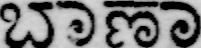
ಬಾಣಾ
